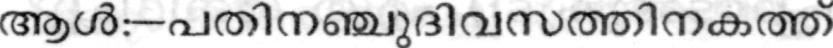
ആള്‍:-പതിനഞ്ചുദിവസത്തിനകത്ത്
